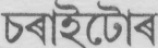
চৰাইটোৰ
